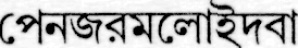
পেনজরমলোইদবা
